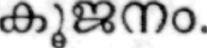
കൂജനം.
